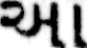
આ
